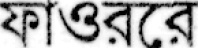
ফাওররে
